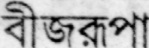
বীজরূপা
